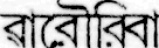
ৱারৌরিবা
